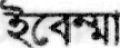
ইবেম্মা
